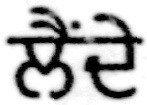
ਲੈਂਦੇ
